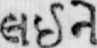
લઈને
